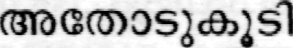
അതോടുകൂടി
